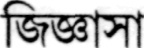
জিজ্ঞাসা
